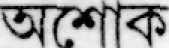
অশোক
